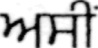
ਅਸੀਂ
